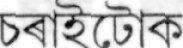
চৰাইটোক
